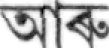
আৰু
